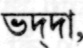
ভদ্দা,
